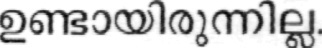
ഉണ്ടായിരുന്നില്ല.
